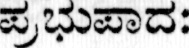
ಪ್ರಭುಪಾದ:
